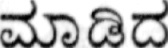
ಮಾಡಿದ
